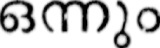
ഒന്നും
